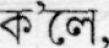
ক'লে,
